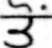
ਤੋਂ
